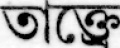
তাক্ত্রে
